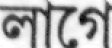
লাগে
